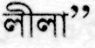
লীলা”
